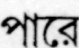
পারে
